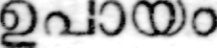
ഉപായം
